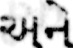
અને
